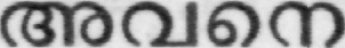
അവനെ
